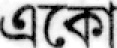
একো
